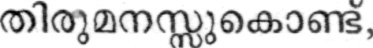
തിരുമനസ്സുകൊണ്ട്,
